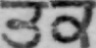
ਤਕ
